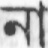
না
